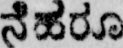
ನೆಹರೂ
